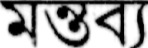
মন্তব্য
